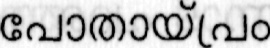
പോതായ്പ്രം
